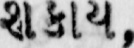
શકાય,
